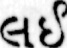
લઈ
